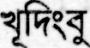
খূদিংবু
